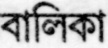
বালিকা
